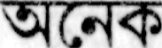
অনেক
